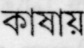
কাষায়
